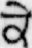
ਕੇ
